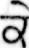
ਕੇ
